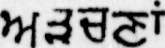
ਅੜਚਣਾਂ
